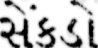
સેંકડો
